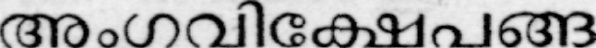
അംഗവിക്ഷേപങ്ങ
